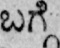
ಬಗ್ಗೆ
